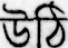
উঠি
